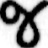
જ
